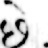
છે.
